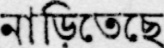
নাড়িতেছে
